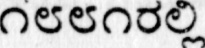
೧೮೮೧ರಲ್ಲಿ
